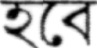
হবে
